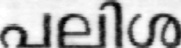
പലിശ
